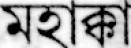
মহাক্কা
